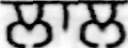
ਲਾਲ
